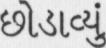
છોડાવ્યું
